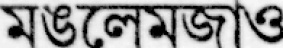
মঙলেমজাও
